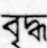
বৃদ্ধ
